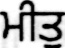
ਮੀਤੁ
